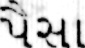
પૈસા
